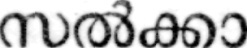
സല്‍ക്കാ
